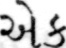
એક
